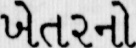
ખેતરનો
